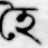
হৈ
